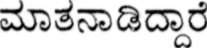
ಮಾತನಾಡಿದ್ದಾರೆ
